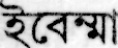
ইবেম্মা
